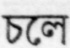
চলে
